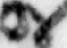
જ
